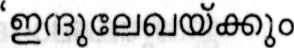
'ഇന്ദുലേഖയ്ക്കും
